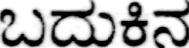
ಬದುಕಿನ
